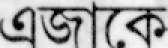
এজাকে
